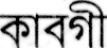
কাবগী
